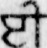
ਈ
